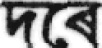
দৰে
